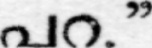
പറ.''
